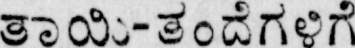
ತಾಯಿ-ತಂದೆಗಳಿಗೆ
